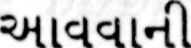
આવવાની
